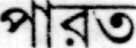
পারত
